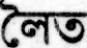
লৈত
